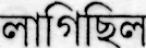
লাগিছিল
